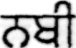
ਨਬੀ
